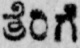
ತೆರಿಗೆ
